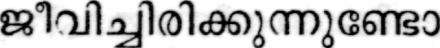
ജീവിച്ചിരിക്കുന്നുണ്ടോ
